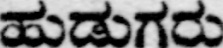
ಹುಡುಗರು
